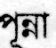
পূন্না
